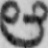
ಆ
